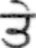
ਤੇ
